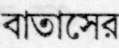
বাতাসের
